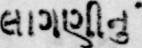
લાગણીનું
